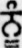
ਨੂੰ
